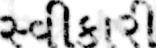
સ્વીકારી
